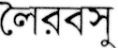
লৈরবসু
